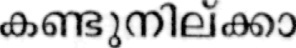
കണ്ടുനില്ക്കാ
